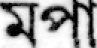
মপা
